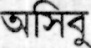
অসিবু
